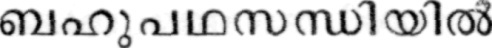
ബഹുപഥസന്ധിയില്‍
